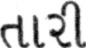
તારી
